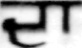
ਦਾ
